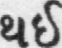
થઈ
